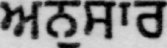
ਅਨੁਸਾਰ
